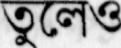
তুলেও
